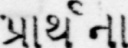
પ્રાર્થના
